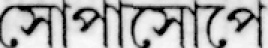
সোপাসোপে
